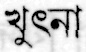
খুৎনা
